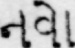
નવો
